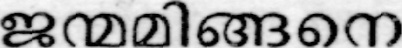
ജന്മമിങ്ങനെ
